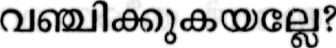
വഞ്ചിക്കുകയല്ലേ?
